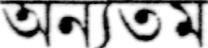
অন্যতম
